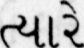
ત્યારે
